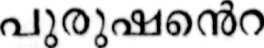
പുരുഷന്റെ
